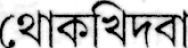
থোকখিদবা
